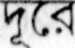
দূরে
